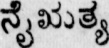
ನೈಋತ್ಯ
